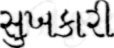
સુખકારી
